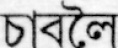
চাবলৈ
